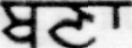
ਬਣਾ
